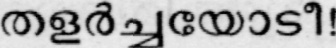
തളര്‍ച്ചയോടീ!
